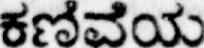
ಕಣಿವೆಯ
